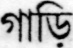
গাড়ি
